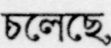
চলেছে,
